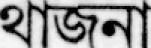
থাজনা
